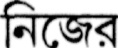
নিজের
